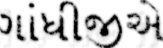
ગાંધીજીએ
